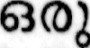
ഒരു
